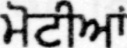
ਮੋਟੀਆਂ
